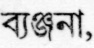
ব্যঞ্জনা,
